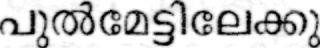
പുല്‍മേട്ടിലേക്കു
